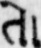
તો
